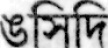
ঙসিদি
